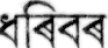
ধৰিবৰ
